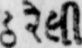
ઠરેલી
